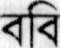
ববি
